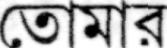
তোমার
